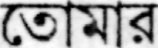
তোমার
